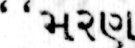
"મરણ
